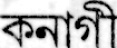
কনাগী
